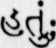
હતું;
